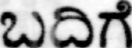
ಬದಿಗೆ
